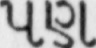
પણ
